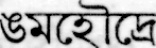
ঙমহৌদ্রে
